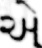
એ
